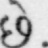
છે.
